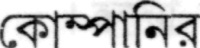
কোম্পানির
